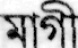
মাগী
